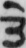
ਤੇ
